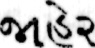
જાહેર
